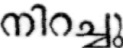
നിറച്ചു
